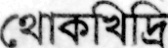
থোকখিদ্রি
